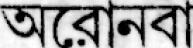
অরোনবা
